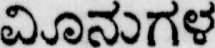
ಮೀನುಗಳ
